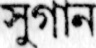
সুগান
